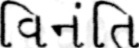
વિનંતિ
